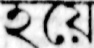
হয়ে
